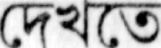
দেখতে
